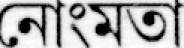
নোংমতা
